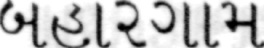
બહારગામ
